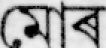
মোৰ
